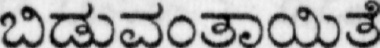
ಬಿಡುವಂತಾಯಿತೆ
